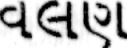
વલણ
